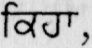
ਕਿਹਾ,
